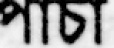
পাচা
